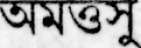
অমত্তসু
